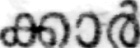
ക്കാര്‍
